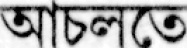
আচলতে
